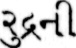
રુદ્રની
